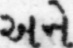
અને
